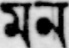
মন
